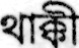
থাক্কী
